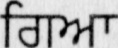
ਗਿਆ
